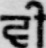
ਵੀ
